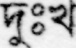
দুঃখ
